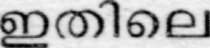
ഇതിലെ
